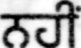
ਨਹੀਂ
